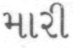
મારી
